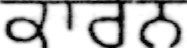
ਕਾਰਨ
